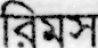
রিমস
